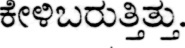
ಕೇಳಿಬರುತ್ತಿತ್ತು.
